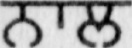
ਨਾਲ
